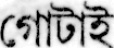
গোটাই
